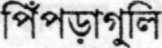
পিঁপড়াগুলি
